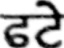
ਫਟੇ
